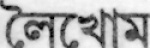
লৈখোম
